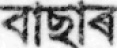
বাছাৰ
